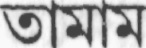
তামাম
